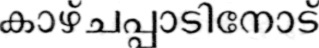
കാഴ്ചപ്പാടിനോട്
